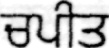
ਚਪੀਤ
